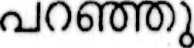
പറഞ്ഞു
